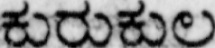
ಕುರುಕುಲ
